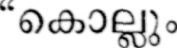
“കൊല്ലും
